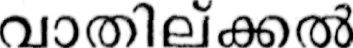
വാതില്ക്കല്‍
